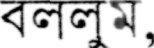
বললুম,
